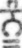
ਨੂੰ
